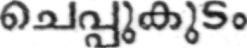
ചെപ്പുകുടം
